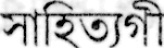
সাহিত্যগী
